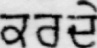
ਕਰਦੇ
